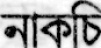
নাকচি
